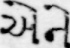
એને
